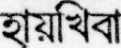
হায়খিবা
